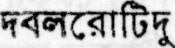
দবলরোটিদু
